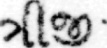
ત્રીજી
